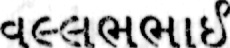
વલ્લભભાઈ
